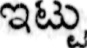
ಇಟ್ಟು
